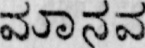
ಮಾನವ
